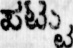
ಪಟ್ಟು
